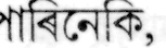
পাৰিনেকি,
